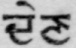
ਦੇਣ
